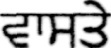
ਵਾਸਤੇ
